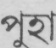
পুহা
